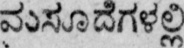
ಮಸೂದೆಗಳಲ್ಲಿ
